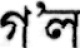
গ'ল
